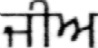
ਜੀਅ
